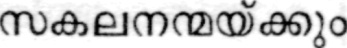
സകലനന്മയ്ക്കും
